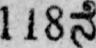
118ನೆ
